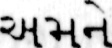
અમને
